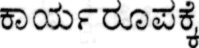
ಕಾರ್ಯರೂಪಕ್ಕೆ
